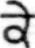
ਕੇ
